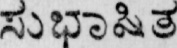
ಸುಭಾಷಿತ
